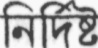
নির্দিষ্ট
